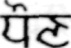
ਧੌਣ
